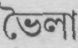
ভৈলা
